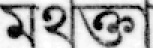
মথক্তা
